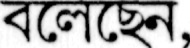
বলেছেন,
